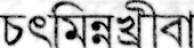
চৎমিন্নখ্রীবা
